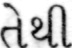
તેથી
